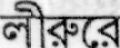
লীরুরে
